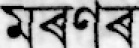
মৰণৰ
